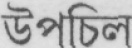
উপচিল
